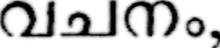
വചനം,
